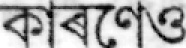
কাৰণেও
